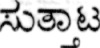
ಸುತ್ತಾಟ
